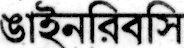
ঙাইনরিবসি
